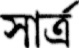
সার্ত্র
